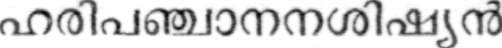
ഹരിപഞ്ചാനനശിഷ്യന്‍
